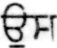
ਉਸ
